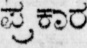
ಪ್ರಕಾರ
